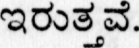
ಇರುತ್ತವೆ.
